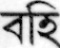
বহি
